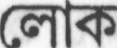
লোক
